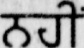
ਨਹੀਂ
